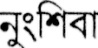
নুংশিবা
